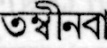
তম্বীনবা
